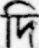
দি
